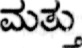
ಮತ್ತು
